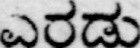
ಎರಡು
